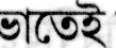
ভাতেই
